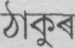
ঠাকুৰ
